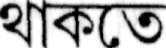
থাকতে
